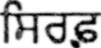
ਸਿਰਫ਼
